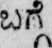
ಬಗ್ಗೆ
